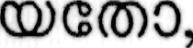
യതോ,
